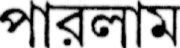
পারলাম
